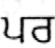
ਪਰ
